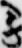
કે
